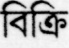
বিক্রি
